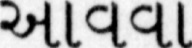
આવવા
